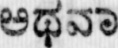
ಅಥವಾ
